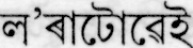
ল'ৰাটোৱেই
